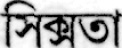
সিক্সতা
